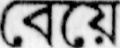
বেয়ে
